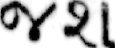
જશ
